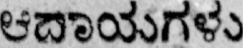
ಆದಾಯಗಳು
